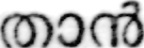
താന്‍
